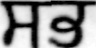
ਸਭ
